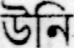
উনি
